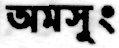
অমসুং
